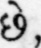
છે,
